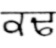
ਕਢ
